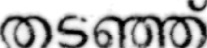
തടഞ്ഞ്
